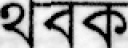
থবক
